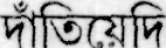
দাঁতিয়েদি
